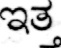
ಇತ್ತ
